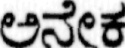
ಅನೇಕ
